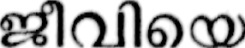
ജീവിയെ
